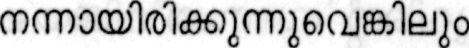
നന്നായിരിക്കുന്നുവെങ്കിലും
